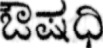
ಔಷಧಿ
